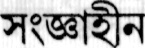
সংজ্ঞাহীন
